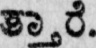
ತ್ತಾರೆ.
